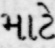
માટે
